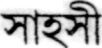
সাহসী
